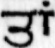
ਤਾਂ
